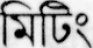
মিটিং
